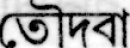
তৌদবা
